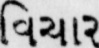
વિચાર
